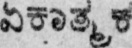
ಏಕಾತ್ಮಕ
